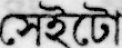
সেইটো
